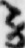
શો
